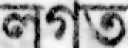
লগত
